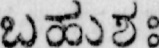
ಬಹುಶಃ
